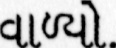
વાળ્યો.
